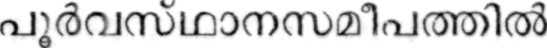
പൂര്‍വസ്ഥാനസമീപത്തില്‍
